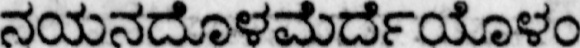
ನಯನದೊಳಮೆರ್ದೆಯೊಳಂ
